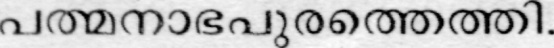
പത്മനാഭപുരത്തെത്തി.
